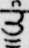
ਤੂੰ
